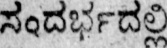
ಸಂದರ್ಭದಲ್ಲಿ
